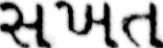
સખત
